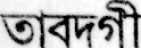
তাবদগী
